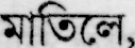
মাতিলে,
